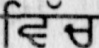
ਵਿੱਚ
